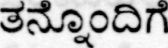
ತನ್ನೊಂದಿಗೆ
